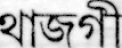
থাজগী
